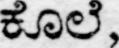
ಕೊಲೆ,
